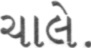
ચાલે.
